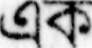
এক
